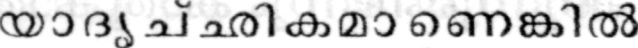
യാദൃച്ഛികമാണെങ്കില്‍
